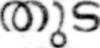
തുട
